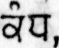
ਕੰਧ,
